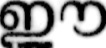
ഈ
